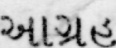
આગ્રહ
